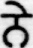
ਨੇ
